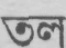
তল
